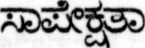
ಸಾಪೇಕ್ಷತಾ
